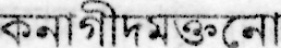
কনাগীদমক্তনো
